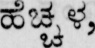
ಹೆಚ್ಚಳ,
